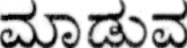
ಮಾಡುವ
